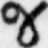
જ
